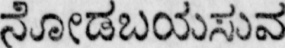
ನೋಡಬಯಸುವ
